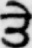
ਤੇ
